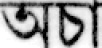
অচা
